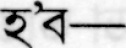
হ'ব-
